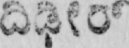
ದಿಢೀರ್
